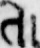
તો
